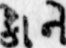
કોને
